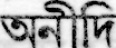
অনীদি
